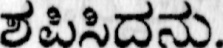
ಶಪಿಸಿದನು.
